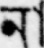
না
